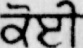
ਕੋਈ
